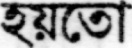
হয়তো
